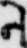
ને
